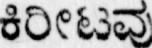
ಕಿರೀಟವು
